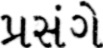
પ્રસંગે
